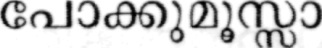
പോക്കുമൂസ്സാ
